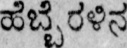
ಹೆಬ್ಬೆರಳಿನ
